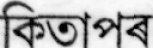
কিতাপৰ
